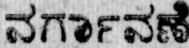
ವರ್ಗಾವಣೆ
